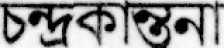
চন্দ্রকান্তনা
